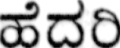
ಹೆದರಿ
